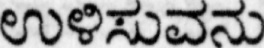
ಉಳಿಸುವನು
